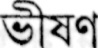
ভীষণ
